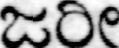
ಜರೀ
